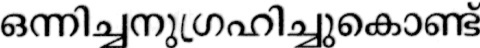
ഒന്നിച്ചനുഗ്രഹിച്ചുകൊണ്ട്
